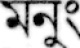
মনুং
